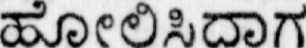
ಹೋಲಿಸಿದಾಗ
